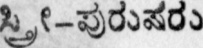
ಸ್ತ್ರೀ-ಪುರುಷರು
